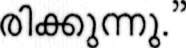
രിക്കുന്നു."
